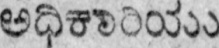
ಅಧಿಕಾರಿಯು
